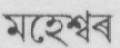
মহেশ্বৰ
